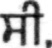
ਸੀ,
